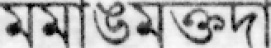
মমাঙমক্তদা
